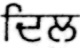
ਦਿਲ
